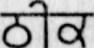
ਠੀਕ
